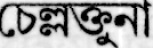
চেল্লক্তুনা
